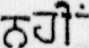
ਨਹੀਂ
